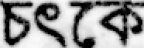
চৎকে
